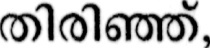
തിരിഞ്ഞ്,
